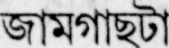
জামগাছটা
